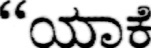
"ಯಾಕೆ
